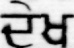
ਦੇਖ
